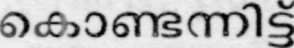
കൊണ്ടന്നിട്ട്
